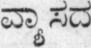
ವ್ಯಾಸದ
